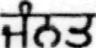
ਜੰਨਤ
